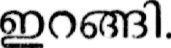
ഇറങ്ങി.
